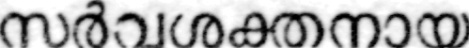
സര്‍വശക്തനായ
